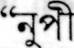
“নুপী
